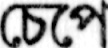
চেপে
